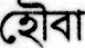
হৌবা
